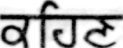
ਕਹਿਣ
